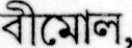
বীমোল,
